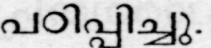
പഠിപ്പിച്ചു.
